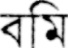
বমি
